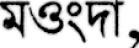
মওংদা,
